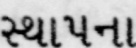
સ્થાપના
